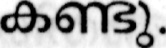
കണ്ടു.
